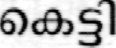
കെട്ടി
